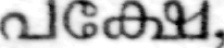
പക്ഷേ,
